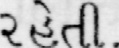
રહેતી.
